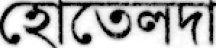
হোতেলদা
